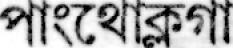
পাংথোক্লগা
